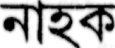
নাহক
